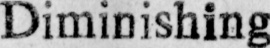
Diminishing
